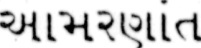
આમરણાંત
